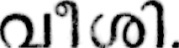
വീശി.
